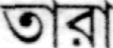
তারা
